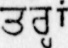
ਤਰ੍ਹਾਂ
